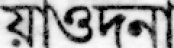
য়াওদনা
